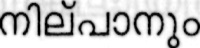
നില്പാനും
